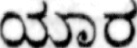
ಯಾರ
